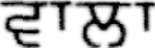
ਵਾਲਾ
